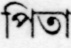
পিতা
